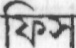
ফিস
